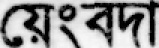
য়েংবদা
